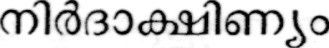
നിര്‍ദാക്ഷിണ്യം
